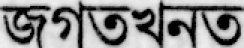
জগতখনত
